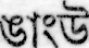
ঙাংউ
